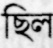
ছিল
